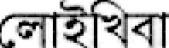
লোইখিবা
